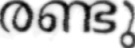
രണ്ടു
